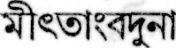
মীৎতাংবদুনা
